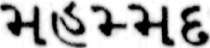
મહમ્મદ
